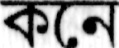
কনে
